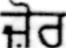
ਜ਼ੋਰ
